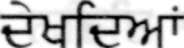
ਦੇਖਦਿਆਂ
